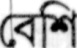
বেশি
